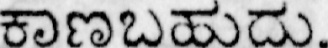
ಕಾಣಬಹುದು.
